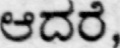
ಆದರೆ,
